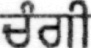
ਚੰਗੀ
